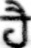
ਹੈ
